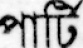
পর্টি
